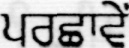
ਪਰਛਾਵੇਂ
